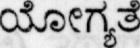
ಯೋಗ್ಯತೆ
